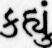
કહ્યું
